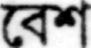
বেশ
